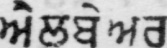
ਐਲਬੇਅਰ
